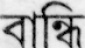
বান্ধি
